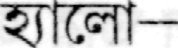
হ্যালো—
